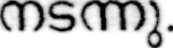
നടന്നു.
